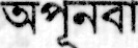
অপূনবা
